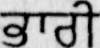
ਭਾਰੀ
